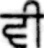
ਵੀ
